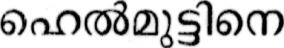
ഹെല്‍മുട്ടിനെ
